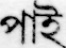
পাই
